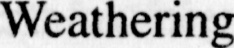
Weathering
